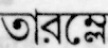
তারম্লে
